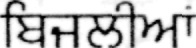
ਬਿਜਲੀਆਂ
